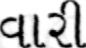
વારી
